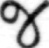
જ
